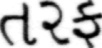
તરફ
